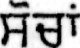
ਸੋਚਾਂ
